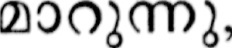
മാറുന്നു,
